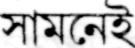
সামনেই
